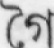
গৈ
